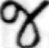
જ
